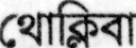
থোক্লিবা
